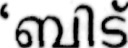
‘ബിട്
